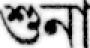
শুনা
